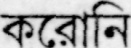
করোনি
